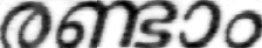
രണ്ടാം
